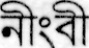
নীংবী
